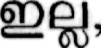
ഇല്ല,
